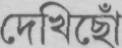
দেখিছোঁ
